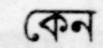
কেন
